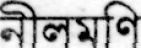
নীলমনি
